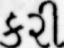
કરી
